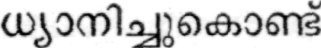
ധ്യാനിച്ചുകൊണ്ട്
